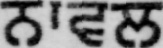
ਨਾਵਲ
